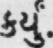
કર્યું.
